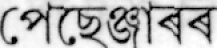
পেছেঞ্জাৰৰ
